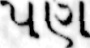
પણ
